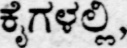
ಕೈಗಳಲ್ಲಿ,
